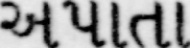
અપાતા
